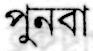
পুনবা
